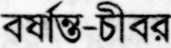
বর্ষান্ত-চীবর
